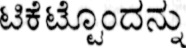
ಟಿಕೆಟ್ಟೊಂದನ್ನು
